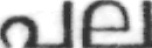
പല
